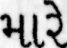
મારે
